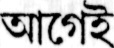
আগেই
